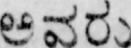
ಅವರು
